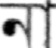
না
